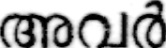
അവര്‍
